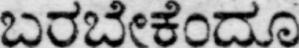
ಬರಬೇಕೆಂದೂ
